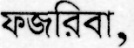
ফজরিবা,
